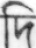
দি
